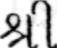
શ્રી
